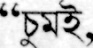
“চুমই,
